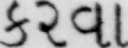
કરવા
